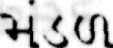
મંડળ
